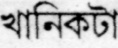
খানিকটা
